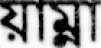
য়াম্না
